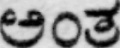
ಅ೦ತ
